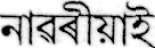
নাৱৰীয়াই
